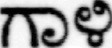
ಗಾಳಿ
